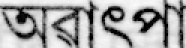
অৱাৎপা
